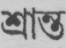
শ্ৰান্ত
